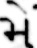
મેં
